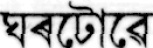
ঘৰটোৱে
